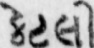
કેટલી
